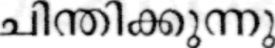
ചിന്തിക്കുന്നു
